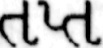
તપ્ત
